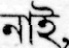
নাই,
